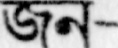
জন-
